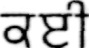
ਕਈ
